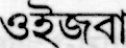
ওইজবা
